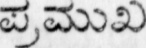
ಪ್ರಮುಖ
